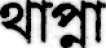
থাপ্না
